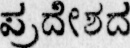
ಪ್ರದೇಶದ
